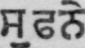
ਸੁਫਨੇ
